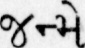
જન્મે
